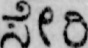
ಸೇರಿ
